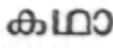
കഥാ
